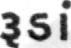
રૂડાં
